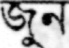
জুন
